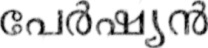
പേര്‍ഷ്യന്‍
